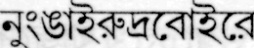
নুংঙাইরুদ্রবোইরে
